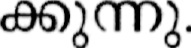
ക്കുന്നു.
